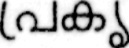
പ്രകൃ
